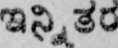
ಇನ್ನಿತರ
